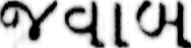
જવાબ
